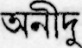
অনীদু
